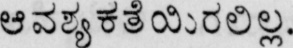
ಆವಶ್ಯಕತೆಯಿರಲಿಲ್ಲ.
